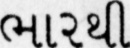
ભારથી
